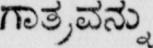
ಗಾತ್ರವನ್ನು
